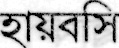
হায়বসি
